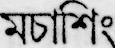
মচাশিং
